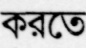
করতে
